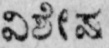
ವಿಶೇಷ
